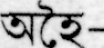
অহৈ-
